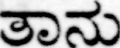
ತಾನು
